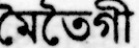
মৈতৈগী
